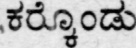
ಕರ್‍ಕೊ೦ಡು
